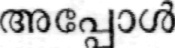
അപ്പോള്‍
